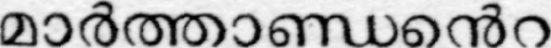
മാര്‍ത്താണ്ഡന്റെ
